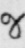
જ
